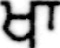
ਖਾ
